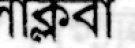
লাক্লবা
